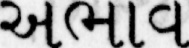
અભાવ
